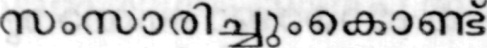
സംസാരിച്ചുംകൊണ്ട്
